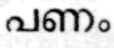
പണം
